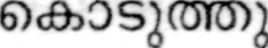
കൊടുത്തു
